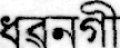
ধৱনগী
